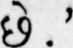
છે.'
